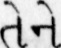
તેને
